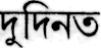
দুদিনত
